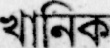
খানিক
